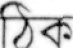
ঠিক
